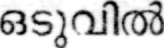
ഒടുവില്‍
